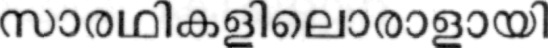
സാരഥികളിലൊരാളായി
